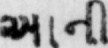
આની
